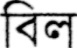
বিল
